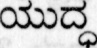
ಯುದ್ಧ
